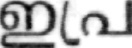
ഇപ്ര
